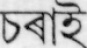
চৰাই
